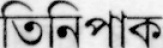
তিনিপাক
